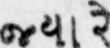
જ્યારે
